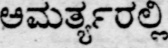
ಅಮರ್ತ್ಯರಲ್ಲಿ
